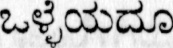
ಒಳ್ಳೆಯದೂ
